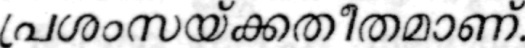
പ്രശംസയ്ക്കതീതമാണ്.
